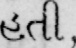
હતી,
